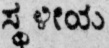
ಸ್ಥಳೀಯ
